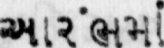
આરંભમાં
